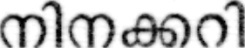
നിനക്കറി
